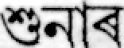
শুনাৰ
